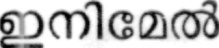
ഇനിമേല്‍
